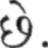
છે.
